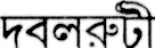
দবলরুটী
